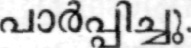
പാര്‍പ്പിച്ചു.
